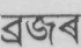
ব্ৰজৰ
